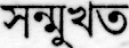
সন্মুখত
